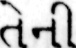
તેની
